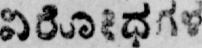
ವಿರೋಧಗಳ
